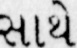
સાથે
